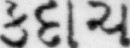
કદાચ
